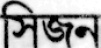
সিজন
